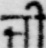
ਜੀ
